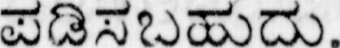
ಪಡಿಸಬಹುದು.
